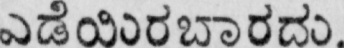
ಎಡೆಯಿರಬಾರದು.
